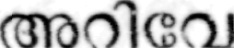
അറിവേ
